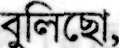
বুলিছো,
